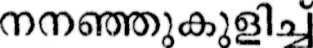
നനഞ്ഞുകുളിച്ച്
